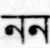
নন
